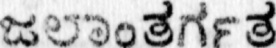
ಜಲಾಂತರ್ಗತ
